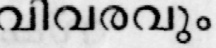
വിവരവും
